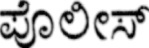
ಪೊಲೀಸ್
